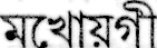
মখোয়গী
